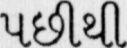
પછીથી
